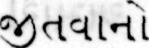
જીતવાનો
